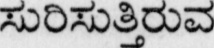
ಸುರಿಸುತ್ತಿರುವ
